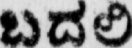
ಬದಲಿ
